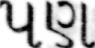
પણ
